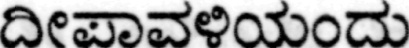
ದೀಪಾವಳಿಯಂದು
